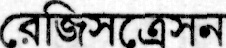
রেজিসত্রেসন
